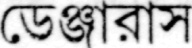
ডেঞ্জারাস
